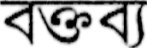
বক্তব্য
